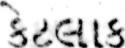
કેટલાક
